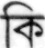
কি
